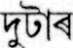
দুটাৰ
